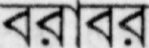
বরাবর
